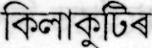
কিলাকুটিৰ
